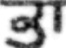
ਭਾ
